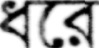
ধরে
